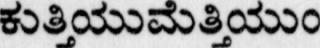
ಕುತ್ತಿಯುಮೆತ್ತಿಯುಂ
